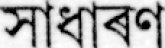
সাধাৰণ
